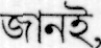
জানই,
